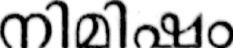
നിമിഷം
